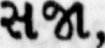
સજા,
